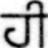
ਹੀ
